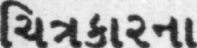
ચિત્રકારના
